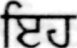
ਇਹ
